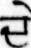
ਦੇ
